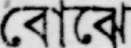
বোঝে
